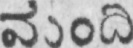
ಮಂದಿ
